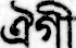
ঐগী
